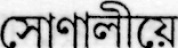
সোণালীয়ে
